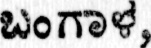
ಬಂಗಾಳ,
